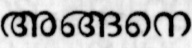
അങ്ങനെ
